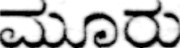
ಮೂರು
